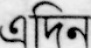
এদিন
